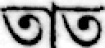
তাত
